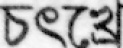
চৎখ্রে
